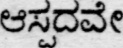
ಆಸ್ಪದವೇ
